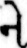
ને
